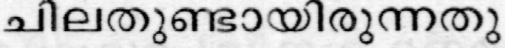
ചിലതുണ്ടായിരുന്നതു
